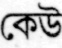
কেউ
